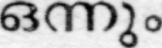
ഒന്നും
